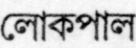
লোকপাল
